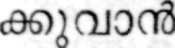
ക്കുവാന്‍
